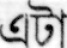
এটা
